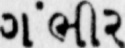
ગંભીર
